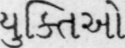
યુક્તિઓ
